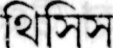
থিসিস
